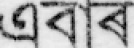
এবাৰ
